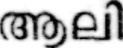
ആലി
